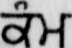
ਕੰਮ
